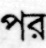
পর
